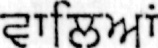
ਵਾਲਿਆਂ
